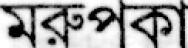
মরুপকা
